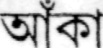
আঁকা
